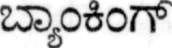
ಬ್ಯಾಂಕಿಂಗ್
